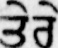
ਤੇਰੇ
